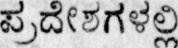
ಪ್ರದೇಶಗಳಲ್ಲಿ
